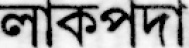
লাকপদা
